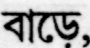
বাড়ে,
